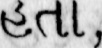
હતા,
